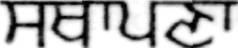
ਸਥਾਪਣਾ
